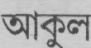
আকুল
